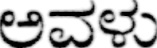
ಅವಳು
